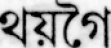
থয়গৈ
